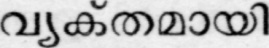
വ്യക്തമായി
